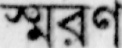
স্মরণ
